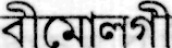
বীমোলগী
